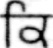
ਕਿ
